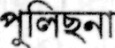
পুলিছনা
